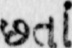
છતાં
